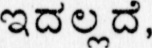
ಇದಲ್ಲದೆ,
